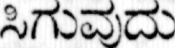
ಸಿಗುವುದು
